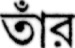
তাঁর
